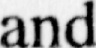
and
